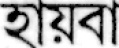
হায়বা
